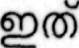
ഇത്
